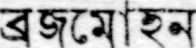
ব্রজমোহন
